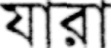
যারা
